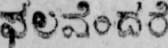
ಫಲವೆಂದರೆ
